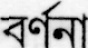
বর্ণনা
